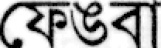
ফেঙবা
